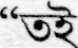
"তই
